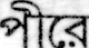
পীরে
